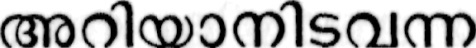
അറിയാനിടവന്ന
